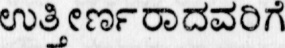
ಉತ್ತೀರ್ಣರಾದವರಿಗೆ
